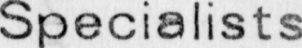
Specialists
